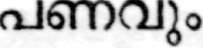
പണവും
